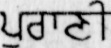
ਪੁਰਾਣੀ
